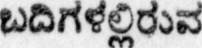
ಬದಿಗಳಲ್ಲಿರುವ
